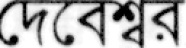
দেবেশ্বর
